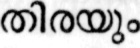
തിരയും
